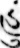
હું
